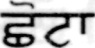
ਛੋਟਾ
